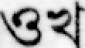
ওখ
